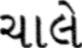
ચાલે
